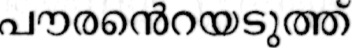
പൌരന്റെയടുത്ത്
